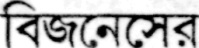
বিজনেসের
